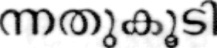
ന്നതുകൂടി
